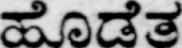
ಹೊಡೆತ
